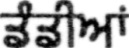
ਡੰਡੀਆਂ
